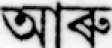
আৰু
